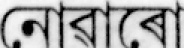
নোৱাৰো
